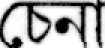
চেনা
